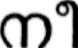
നീ
